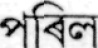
পৰিল
